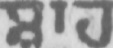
ਬਾਹ
